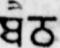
ਬੈਠ
